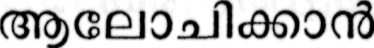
ആലോചിക്കാന്‍
